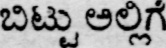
ಬಿಟ್ಟುಅಲ್ಲಿಗೆ
